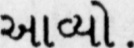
આવ્યો.
